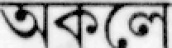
অকলে
